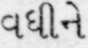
વધીને
